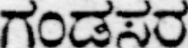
ಗಂಡಸರ
